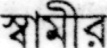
স্বামীর
